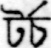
টর্চ
